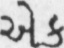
એક
